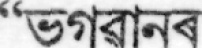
"ভগৱানৰ
